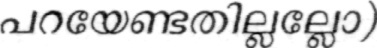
പറയേണ്ടതില്ലല്ലോ)
